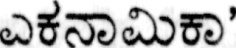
ಎಕನಾಮಿಕಾ'
